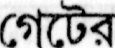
গেটের
